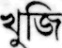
খুজি
